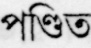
পণ্ডিত
